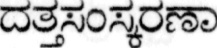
ದತ್ತಸಂಸ್ಕರಣಾ
